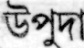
উপুদা
